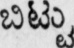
ಬಿಟ್ಟು
